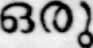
ഒരു
